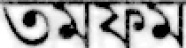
তমফম
